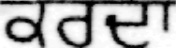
ਕਰਦਾ
